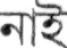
নাই
